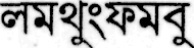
লমথুংফমবু
